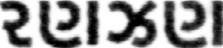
રણઝણ
